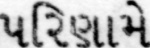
પરિણામે
